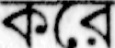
করে
